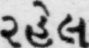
રહેલ
